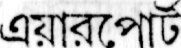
এয়ারপোর্ট
